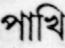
পাখি
